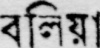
বলিয়া
